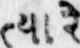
ત્યારે
